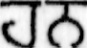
ਹਨ
